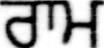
ਰਾਮ
